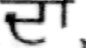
ਦਾ,
